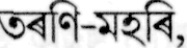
তৰণি-মহৰি,
